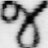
જ
